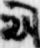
એ
